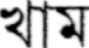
খাম
